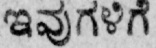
ಇವುಗಳಿಗೆ
